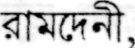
রামদেনী,
